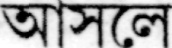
আসলে
